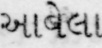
આવેલા
